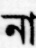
না
